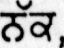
ਨੱਕ,
